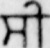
ਸੀ
